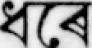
ধৰে
